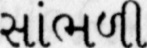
સાંભળી
